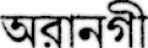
অরানগী
